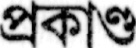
প্রকাণ্ড
